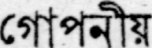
গোপনীয়
